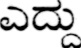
ಎದ್ದು
